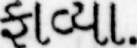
ફાવ્યા.
